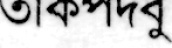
তাকপদবু
